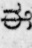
ಈ
